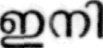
ഇനി
